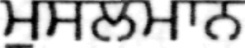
ਮੁਸਲਮਾਨ
